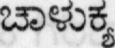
ಚಾಳುಕ್ಯ
